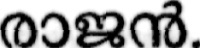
രാജന്‍.
